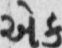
એક
